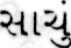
સાચું
